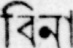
বিনা
